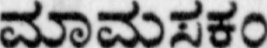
ಮಾಮಸಕಂ
